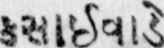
,કસાઈવાડે
